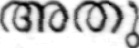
അതു
